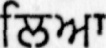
ਲਿਆ
